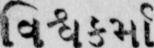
વિશ્વકર્મા
